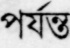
পর্যন্ত
